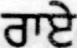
ਰਾਏ
